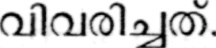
വിവരിച്ചത്.
